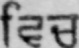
ਵਿਚ
